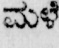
ಮಳೆ
